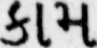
કામ
